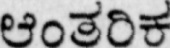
ಆಂತರಿಕ
